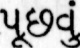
પૂછવું
